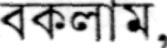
বকলাম,
